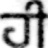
ਹੀ
